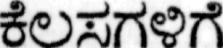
ಕೆಲಸಗಳಿಗೆ
